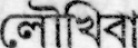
লৌখিবা
